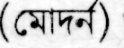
(মোর্দন)
